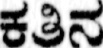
ಕತಿನ
